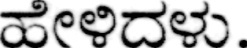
ಹೇಳಿದಳು.
